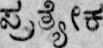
ಪ್ರತ್ಯೇಕ
